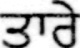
ਤਾਰੇ
